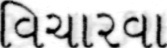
વિચારવા
